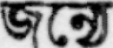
জন্যে
